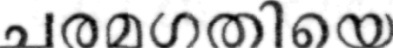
ചരമഗതിയെ
